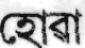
হোৱা
